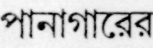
পানাগারের
